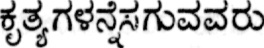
ಕೃತ್ಯಗಳನ್ನೆಸಗುವವರು
